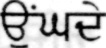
ਉਂਘਦੇ
